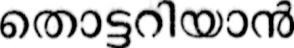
തൊട്ടറിയാന്‍
